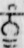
ਨੂੰ
